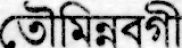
তৌমিন্নবগী
